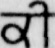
ਕੀ
